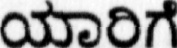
ಯಾರಿಗೆ
